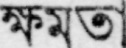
ক্ষমতা
